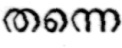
തന്നെ
